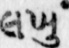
લખું
